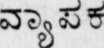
ವ್ಯಾಪಕ
